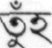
তুঁহ
